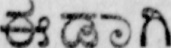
ಈಡಾಗಿ
